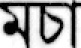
মচা
